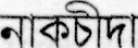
নাকচীদা
